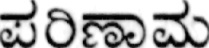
ಪರಿಣಾಮ
